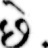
છે.
